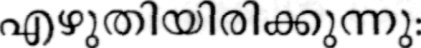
എഴുതിയിരിക്കുന്നു:
